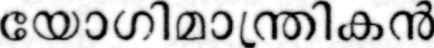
യോഗിമാന്ത്രികന്‍
